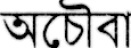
অচৌবা
